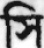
সি
